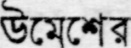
উমেশের
